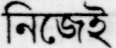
নিজেই
